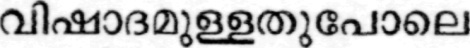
വിഷാദമുള്ളതുപോലെ
